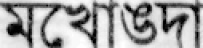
মখোঙদা
